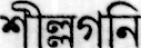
শীল্লগনি
